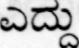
ಎದ್ದು
